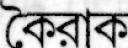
কৈরাক
